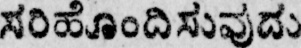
ಸರಿಹೊಂದಿಸುವುದು
